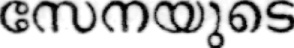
സേനയുടെ
